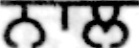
ਨਾਲ
